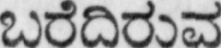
ಬರೆದಿರುವ
